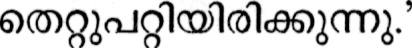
തെറ്റുപറ്റിയിരിക്കുന്നു.’
